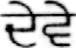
ਦੇਵੇ
